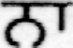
ਨਾ
